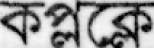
কপ্লক্লে
